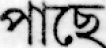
পাছে
